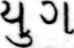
યુગ
